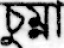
চুম্না
